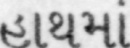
હાથમાં
